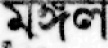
মঙ্গল
